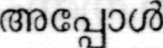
അപ്പോള്‍
